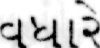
વધારે
